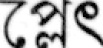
প্লেৎ
